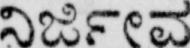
ನಿರ್ಜೀವ
